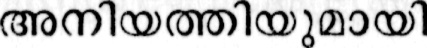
അനിയത്തിയുമായി
